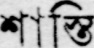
শাস্তি
